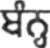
ਬੰਨ੍ਹ
